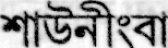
শাউনীংবা
